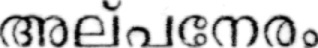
അല്പനേരം
